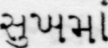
સુખમાં
